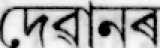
দেৱানৰ
